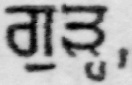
ਗੁੜ੍ਹ,
